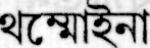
থম্মোইনা
